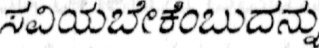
ಸವಿಯಬೇಕೆಂಬುದನ್ನು
